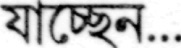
যাচ্ছেন...
